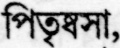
পিতৃষ্বসা,
